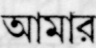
আমার
